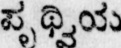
ಪೃಥ್ವಿಯ
